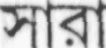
সারা
